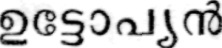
ഉട്ടോപ്യന്‍
